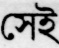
সেই
